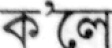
ক'লে
